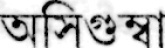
অসিগুম্বা
